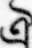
ঐ
